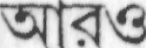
আরও
